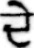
ਦੇ
